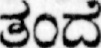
ತಂದೆ
